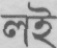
লই
